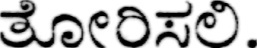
ತೋರಿಸಲಿ.
